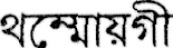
থম্মোয়গী
